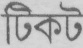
টিকট
